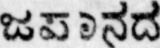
ಜಪಾನದ
